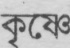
কৃষ্ণে
